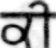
ਕੀ
